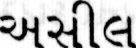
અસીલ
